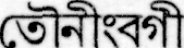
তৌনীংবগী
